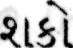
શકો
